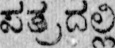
ಪತ್ರದಲ್ಲಿ
